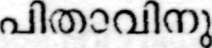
പിതാവിനു
